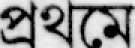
প্রথমে
